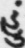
હું
